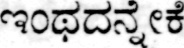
ಇಂಥದನ್ನೇಕೆ
